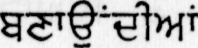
ਬਣਾਉਂਦੀਆਂ
